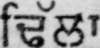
ਢਿੱਲਾ
